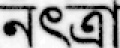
নৎত্রা
